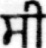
ਸੀ
